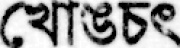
খোঙচৎ
